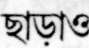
ছাড়াও
